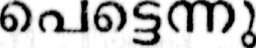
പെട്ടെന്നു
